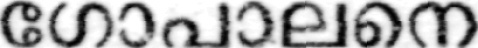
ഗോപാലനെ
